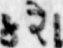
કરો
